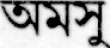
অমসু
